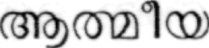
ആത്മീയ
